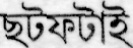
ছটফটাই
